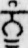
ਨੂੰ
